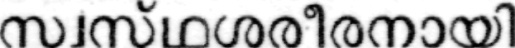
സ്വസ്ഥശരീരനായി
